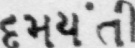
દમયંતી
